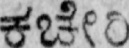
ಕಚೇರಿ
